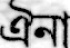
ঐনা
